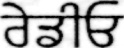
ਰੇਡੀਓ
